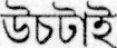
উচটাই
